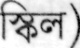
স্কিল)
